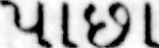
પાછા
